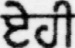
ਏਹੀ
